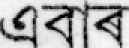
এবাৰ
